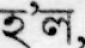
হ'ল,
